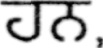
ਹਨ,
